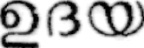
ഉദയ
